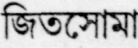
জিতসোমা
